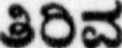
ತಿರಿವ
